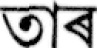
তাৰ
